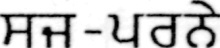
ਸਜ-ਪਰਨੇ
